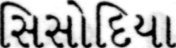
સિસોદિયા
